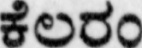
ಕೆಲರಂ
